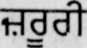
ਜ਼ਰੂਰੀ
